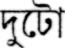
দুটো
